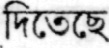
দিতেছে
